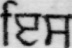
ਇਸ
